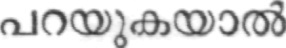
പറയുകയാല്‍
